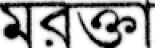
মরক্তা
